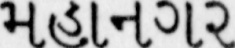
મહાનગર
